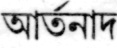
আর্তনাদ
